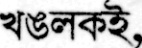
খঙলকই,
